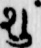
શું
